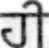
ਹੀ
